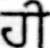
ਹੀ
